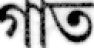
গাত
